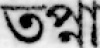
তপ্না
